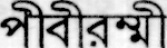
পীবীরম্মী
